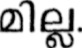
മില്ല.
